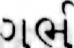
ગર્ભ
